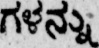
ಗಳನ್ನು
